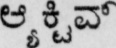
ಆಕ್ಟಿವ್
